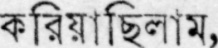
করিয়াছিলাম,
